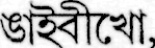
ঙাইবীখো,
